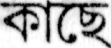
কাছে
